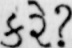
કરે?
